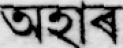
অহাৰ
